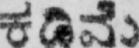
ಕಡಿಮೆ
